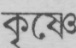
কৃষ্ণে
